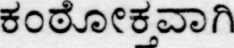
ಕಂಠೋಕ್ತವಾಗಿ
